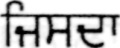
ਜਿਸਦਾ
